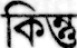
কিন্তু
